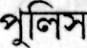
পুলিস
